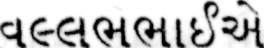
વલ્લભભાઈએ
